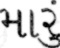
મારું
